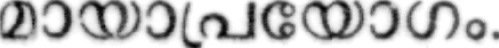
മായാപ്രയോഗം.
